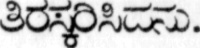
ತಿರಸ್ಕರಿಸಿದನು.
